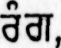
ਰੰਗ,
